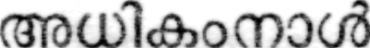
അധികംനാള്‍
